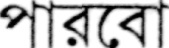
পারবো
